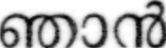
ഞാന്‍
